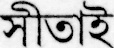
সীতাই
